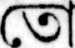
তো
